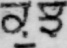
ਕੁਝ
